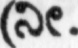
(ನೀ.
